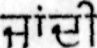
ਜਾਂਦੀ
